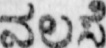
ವಲಸೆ
